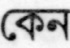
কেন
